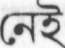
নেই
